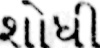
શોધી
